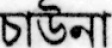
চাউনা
